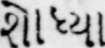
શોધ્યા
